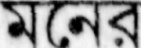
মনের
